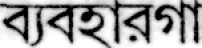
ব্যবহারগা
